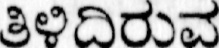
ತಿಳಿದಿರುವ
